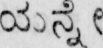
ಯನ್ನೇ
